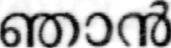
ഞാന്‍
